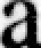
a
